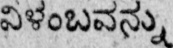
ವಿಳಂಬವನ್ನು
